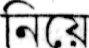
নিয়ে
